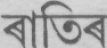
ৰাতিৰ
